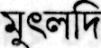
মুৎলদি
